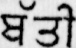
ਬੱਤੀ
